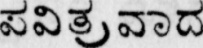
ಪವಿತ್ರವಾದ
